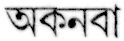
অকনবা
